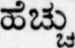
ಹೆಚ್ಚು
